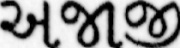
અજાજી
